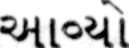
આવ્યો
